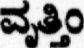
ವೃತ್ತಿಂ
